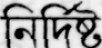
নিৰ্দিষ্ট
